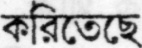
করিতেছে
